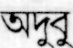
অদুবু
